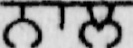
ਨਾਲ
